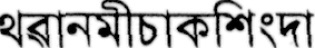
থৱানমীচাকশিংদা
